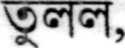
তুলল,
